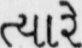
ત્યારે
